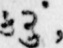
કરું,
